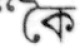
"কৈ
